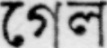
গেল
